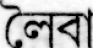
লৈবা
